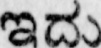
ಇದು
